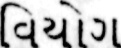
વિયોગ
